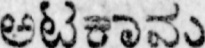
ಅಟಕಾಮ
